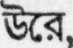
উরে,
